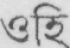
ওহি
